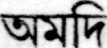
অমদি
